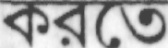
করতে
